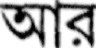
আর
